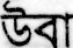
উবা
